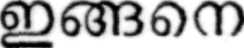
ഇങ്ങനെ
